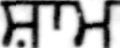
ਸ਼ਾਮ
